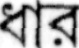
ধার
